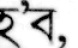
হ'ব,
